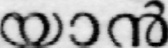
യാന്‍
